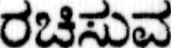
ರಚಿಸುವ
